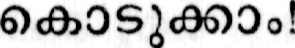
കൊടുക്കാം!
